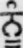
ਨੂੰ
